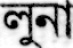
লুনা
